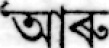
'আৰু
